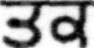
ਤਕ
